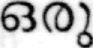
ഒരു
